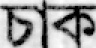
চাক
